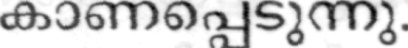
കാണപ്പെടുന്നു.
